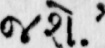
જશે.'
